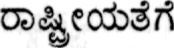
ರಾಷ್ಟ್ರೀಯತೆಗೆ
